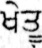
ਖੇਤੂ
